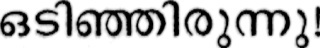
ഒടിഞ്ഞിരുന്നു!
